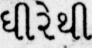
ધીરેથી
